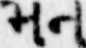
મન
